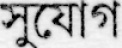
সুযোগ
